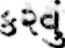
કરવું
